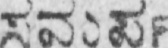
ಸಮರ್ಪ
